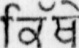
ਕਿੱਥੇ
